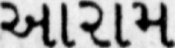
આરામ
